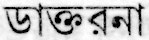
ডাক্তরনা
